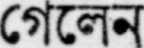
গেলেন
